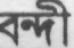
বন্দী
